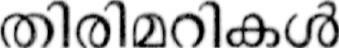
തിരിമറികള്‍
